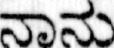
ನಾನು
